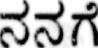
ನನಗೆ
